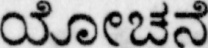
ಯೋಚನೆ
